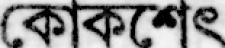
কোকশেৎ
